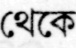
থেকে
